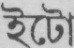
ইটো
